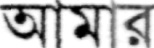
আমার
